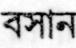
বসান
